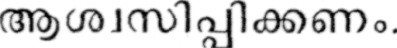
ആശ്വസിപ്പിക്കണം.
